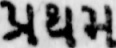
પ્રથમ
